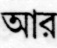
আর
